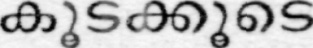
കൂടക്കൂടെ
